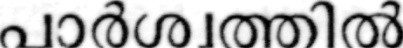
പാര്‍ശ്വത്തില്‍
